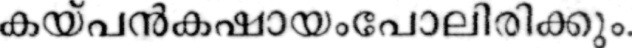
കയ്പന്‍കഷായംപോലിരിക്കും.
